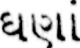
ઘણાં
